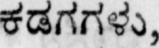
ಕಡಗಗಳು,
